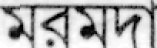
মরমদা
